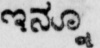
ಇನ್ನೂ
